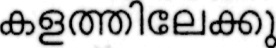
കളത്തിലേക്കു
